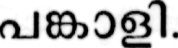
പങ്കാളി.
